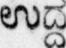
ಉದ್ದ
